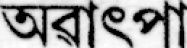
অৱাৎপা
